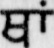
ਥਾਂ
